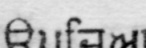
ਉਪਜਿਆ
